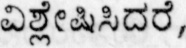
ವಿಶ್ಲೇಷಿಸಿದರೆ,
